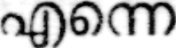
എന്നെ
